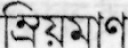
ম্রিয়মাণ
